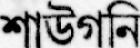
শাউগনি
